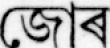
জোৰ
